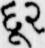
દૂર
